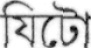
যিটো
